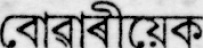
বোৱাৰীয়েক
